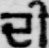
ਦੀ
